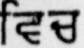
ਵਿਚ
